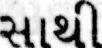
સાથી
